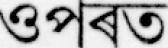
ওপৰত
